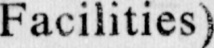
Facilities)
